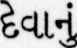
દેવાનું
